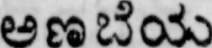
ಅಣಬೆಯ
